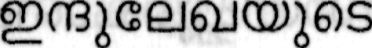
ഇന്ദുലേഖയുടെ
